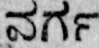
ವರ್ಗ
